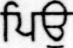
ਪਿਉ
